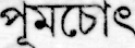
পূমচোৎ
